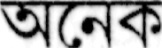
অনেক
